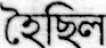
হৈছিল
